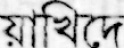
য়াখিদে
